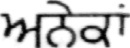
ਅਨੇਕਾਂ
